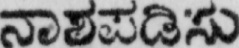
ನಾಶಪಡಿಸು
